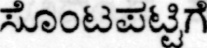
ಸೊಂಟಪಟ್ಟಿಗೆ
